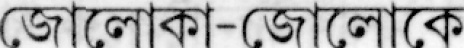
জোলোকা-জোলোকে
